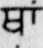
ਥਾਂ
